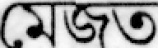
মেজত
